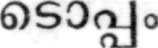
ടൊപ്പം
